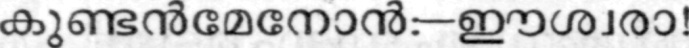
കുണ്ടന്‍മേനോന്‍:-ഈശ്വരാ!
